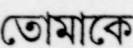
তোমাকে
